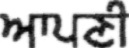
ਆਪਣੀ
